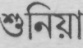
শুনিয়া
